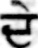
ਦੇ
